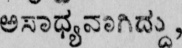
ಅಸಾಧ್ಯವಾಗಿದ್ದು,
